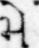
મેં
